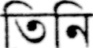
তিনি
